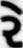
રે
